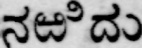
ನಱಿದು
